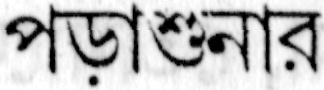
পড়াশুনার
